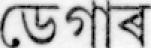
ডেগাৰ
